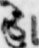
હો
